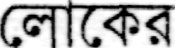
লোকের
